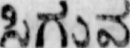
ಸಿಗುವ
